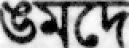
ঙমদে
